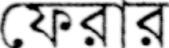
ফেরার
